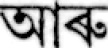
আৰু
